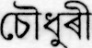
চৌধুৰী
